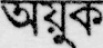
অয়ুক
